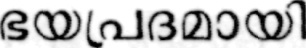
ഭയപ്രദമായി
